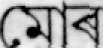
মোৰ
